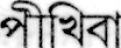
পীখিবা
